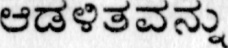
ಆಡಳಿತವನ್ನು
